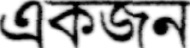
একজন
